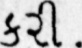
કરી.
